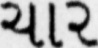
ચાર
